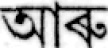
আৰু
